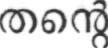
തന്റെ
